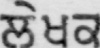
ਲੇਖਕ
